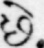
છે.
